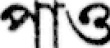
পাও
